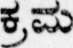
ಕ್ರಮ
